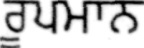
ਰੂਪਮਾਨ
